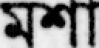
মশা
